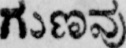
ಗುಣವು
